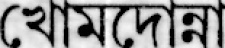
খোমদোন্না
